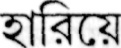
হারিয়ে
